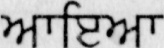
ਆਇਆ
